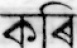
কৰি
